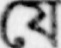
যে
